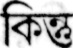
কিন্তু
